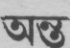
অন্ত
